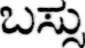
ಬಸ್ಸು
